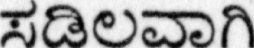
ಸಡಿಲವಾಗಿ
